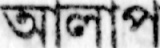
আলাপ
